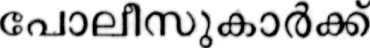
പോലീസുകാര്‍ക്ക്
